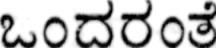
ಒಂದರಂತೆ
